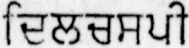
ਦਿਲਚਸਪੀ
